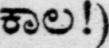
ಕಾಲ!)
